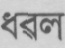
ধৱল
